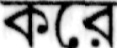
করে
